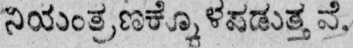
‘ನಿಯಂತ್ರಣಕ್ಕೊಳಪಡುತ್ತವೆ.
